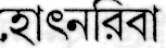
হোৎনরিবা
